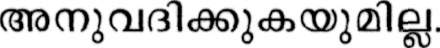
അനുവദിക്കുകയുമില്ല.
